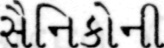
સૈનિકોની
